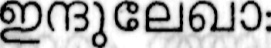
ഇന്ദുലേഖാ:
